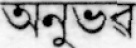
অনুভৱ
